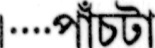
।....পাঁচটা
